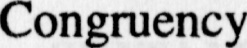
Congruency
